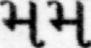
મમ
